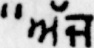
''ਅੱਜ
